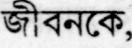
জীবনকে,
